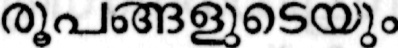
രൂപങ്ങളുടെയും
